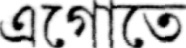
এগোতে
